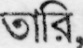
তারি,
